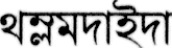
থম্লমদাইদা
